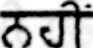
ਨਹੀਂ
